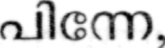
പിന്നേ,
